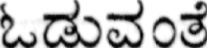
ಓಡುವಂತೆ
